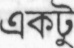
একটু
